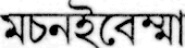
মচনইবেম্মা
